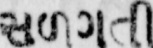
સળગતી
